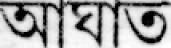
আঘাত
